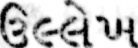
ઉલ્લેખ
